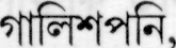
গালিশপনি,
